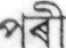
পৰী
